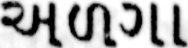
અળગા
